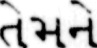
તેમને
